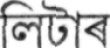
লিটাৰ
